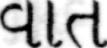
વાત
